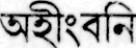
অহীংবনি
